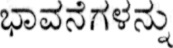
ಭಾವನೆಗಳನ್ನು
